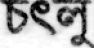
চৎলু
